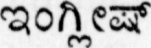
ಇಂಗ್ಲೀಷ್
